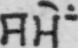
ਸਮੇਂ
